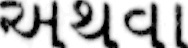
અથવા
